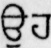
ਉਹ
